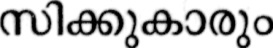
സിക്കുകാരും
